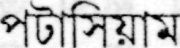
পটাসিয়াম
